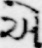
એ
